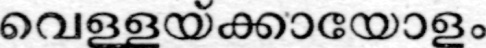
വെള്ളയ്ക്കായോളം
